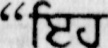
''ਇਹ
